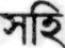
সহি
